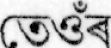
তেওঁৰ
